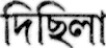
দিছিলা
